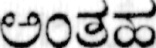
ಅಂತಹ
